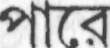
পারে
